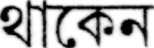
থাকেন
